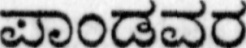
ಪಾಂಡವರ
